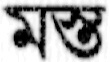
মস্ত
